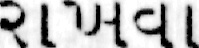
રાખવા
